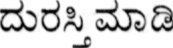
ದುರಸ್ತಿಮಾಡಿ
